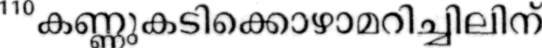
110കണ്ണുകടിക്കൊഴാമറിച്ചിലിന്
